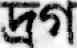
দ্রগ
